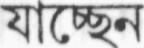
যাচ্ছেন
